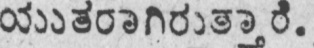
ಯುತರಾಗಿರುತ್ತಾರೆ.
